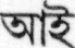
আই
